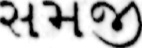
સમજી
